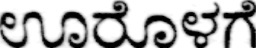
ಊರೊಳಗೆ
